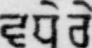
ਵਧੇਰੇ
